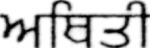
ਅਥਿਤੀ
